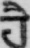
ਹੈ
